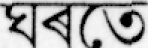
ঘৰতে
